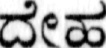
ದೇಹ
